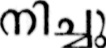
നിച്ചു
